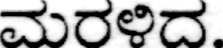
ಮರಳಿದ.
